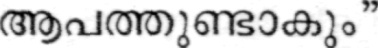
ആപത്തുണ്ടാകും”
